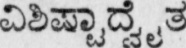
ವಿಶಿಷ್ಟಾದ್ವೈತ
